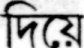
দিয়ে
